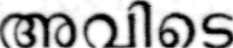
അവിടെ
